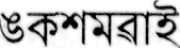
ঙকশমৱাই
